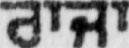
ਰਾਜਾ
